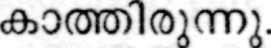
കാത്തിരുന്നു.
